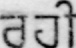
ਰਹੀ
